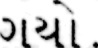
ગયો.
